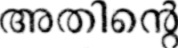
അതിന്റെ
